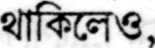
থাকিলেও,
